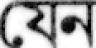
যেন
